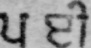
ਪਈ
